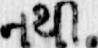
નથી.
